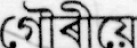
গৌৰীয়ে
